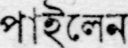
পাইলেন
